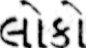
લોકો
